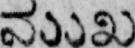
ಮುಖ
